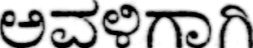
ಅವಳಿಗಾಗಿ
